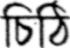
চিঠি
